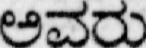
ಅವರು
